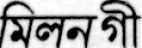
মিলনগী
